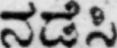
ನಡೆಸಿ
